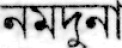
নমদুনা
